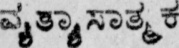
ವ್ಯತ್ಯಾಸಾತ್ಮಕ
